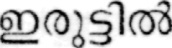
ഇരുട്ടില്‍
